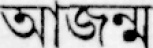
আজন্ম
